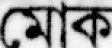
মোক
